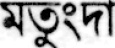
মতুংদা
